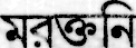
মরক্তনি
